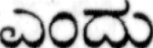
ಎಂದು
